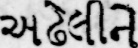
અઢેલીને
